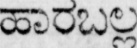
ಹಾರಬಲ್ಲ
